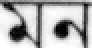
মন
